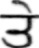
ਤੇ
